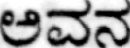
ಅವನ
